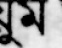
য়ুম
